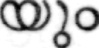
യും
